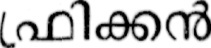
ഫ്രിക്കന്‍
